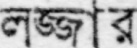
লজ্জার
